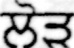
ਲੋੜ
